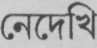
নেদেখি
